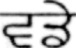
ਵਡੇ
